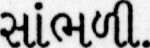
સાંભળી.
